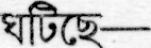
ঘটিছে-
